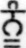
ਨੂੰ
